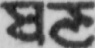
ਬਣ
